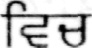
ਵਿਚ
